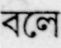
বলে
